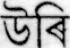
উৰি
